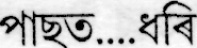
পাছত....ধৰি
